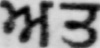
ਅਤ
